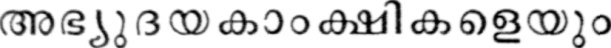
അഭ്യുദയകാംക്ഷികളെയും
